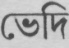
ভেদি
